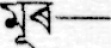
মূৰ-
